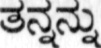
ತನ್ನನ್ನು
